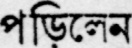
পড়িলেন
